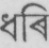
ধৰি
